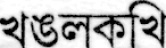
খঙলকখি
